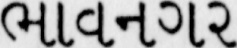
ભાવનગર
